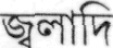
জ্বলাদি
